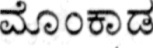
ಮೊಂಕಾಡ
